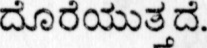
ದೊರೆಯುತ್ತದೆ.
